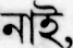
নাই,
